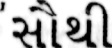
સૌથી
